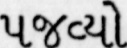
પજવ્યો
